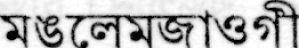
মঙলেমজাওগী
